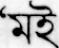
'মই
